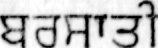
ਬਰਸਾਤੀ
